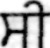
ਸੀ
